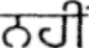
ਨਹੀਂ
